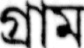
গ্রাম
